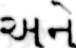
અને
